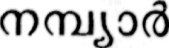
നമ്പ്യാര്‍
